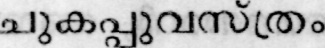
ചുകപ്പുവസ്ത്രം
